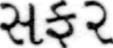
સફર
